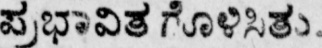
ಪ್ರಭಾವಿತಗೊಳಿಸಿತು.
